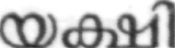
യക്ഷി
